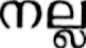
നല്ല
